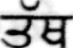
ਤੱਥ
